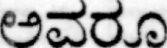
ಅವರೂ
